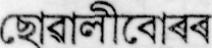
ছোৱালীবোৰৰ
